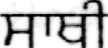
ਸਾਥੀ
